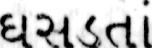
ઘસડતાં
